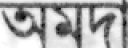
অমদা
